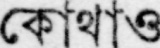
কোথাও
